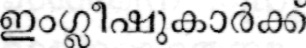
ഇംഗ്ലീഷുകാര്‍ക്ക്
